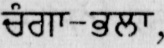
ਚੰਗਾ-ਭਲਾ,
